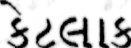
કેટલાક
